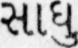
સાધુ
